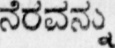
ನೆರವನ್ನು
